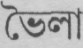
ভৈলা
